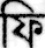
ফি
